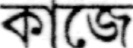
কাজে
